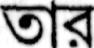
তার
